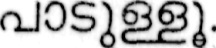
പാടുള്ളൂ.
